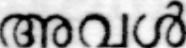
അവള്‍
